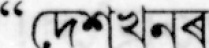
"দেশখনৰ
